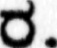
ರ.
